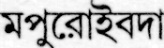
মপুরোইবদা
